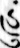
હું
